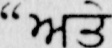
''ਅਤੇ
